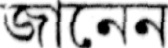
জানেন
